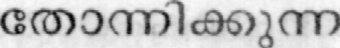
തോന്നിക്കുന്ന
